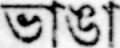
ভাঙা
